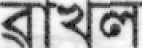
ৱাখল
